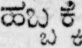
ಹಬ್ಬಕ್ಕೆ
